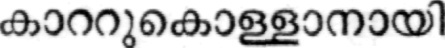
കാററുകൊള്ളാനായി
